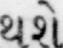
થશે
